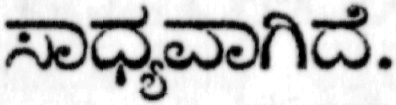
ಸಾಧ್ಯವಾಗಿದೆ.
